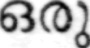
ഒരു
